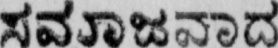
ಸಮಾಜವಾದ
